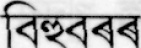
বিহুবৰৰ
